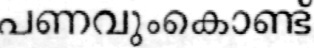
പണവുംകൊണ്ട്
